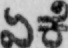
ಏಕೆ
